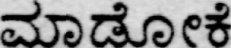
ಮಾಡೋಕೆ
